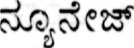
ನ್ಯೂನೇಜ್
